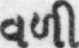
વળી
